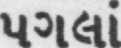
પગલાં
